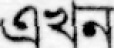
এখন
